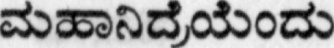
ಮಹಾನಿದ್ರೆಯೆಂದು
